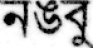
নঙবু
